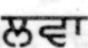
ਲਵਾ
